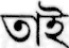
তাই
